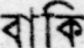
বাকি
